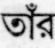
তাঁর
